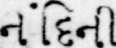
નંદિની
